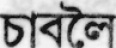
চাবলৈ
